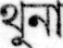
থুনা
